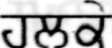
ਹਲਕੇ
